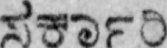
ಸರ್ಕಾರಿ
